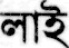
লাই
